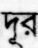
দূর
